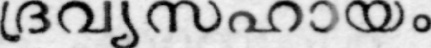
ദ്രവ്യസഹായം
